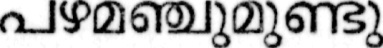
പഴമഞ്ചുമുണ്ടു
